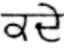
ਕਦੇ
